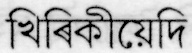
খিৰিকীয়েদি
